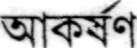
আকর্ষণ
